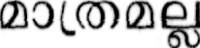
മാത്രമല്ല
